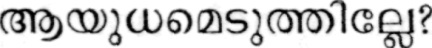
ആയുധമെടുത്തില്ലേ?
